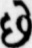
છે
